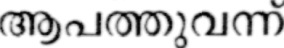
ആപത്തുവന്ന്
